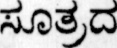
ಸೂತ್ರದ
